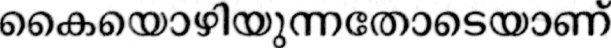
കൈയൊഴിയുന്നതോടെയാണ്
